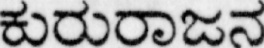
ಕುರುರಾಜನ
